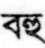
বহু
